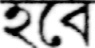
হবে
